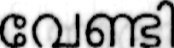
വേണ്ടി
